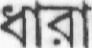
ধারা
